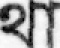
থা
